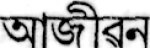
আজীৱন
